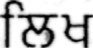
ਲਿਖ
